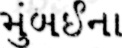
મુંબઈના
